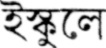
ইস্কুলে
